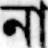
না
